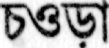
চওড়া
